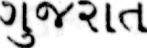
ગુજરાત
